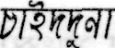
চাইদদুনা
